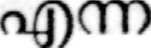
എന്ന
